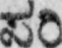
ಪರಿ
